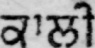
ਕਾਲੀ
